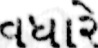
વધારે
